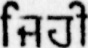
ਜਿਹੀ
